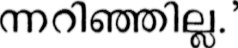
ന്നറിഞ്ഞില്ല.’
